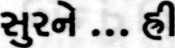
સુરને......હી
